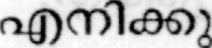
എനിക്കു
